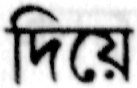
দিয়ে
